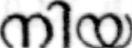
നിയ
